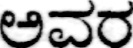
ಅವರ
